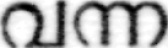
വന്ന
